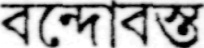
বন্দোবস্ত
